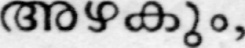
അഴകും,
